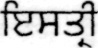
ਇਸਤ੍ਰੀ
